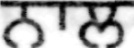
ਨਾਲ
